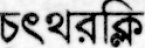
চৎথরক্লি
